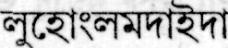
লুহোংলমদাইদা
